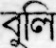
বুলি
